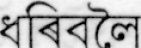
ধৰিবলৈ
